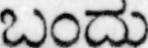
ಬಂದು
